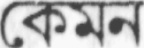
কেমন
